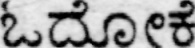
ಓದೋಕೆ
